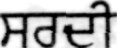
ਸਰਦੀ
